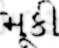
મૂકી
